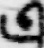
এ
